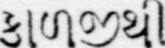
કાળજીથી
